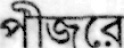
পীজরে
